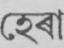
হেৰা
